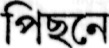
পিছনে
